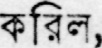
করিল,
